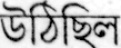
উঠিছিল
